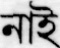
নাই
